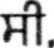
ਸੀ,
